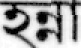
হন্না
